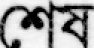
শেষ
